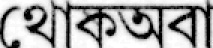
থোকঅবা
